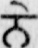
ਨੇ
